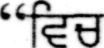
''ਵਿਚ
